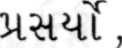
પ્રસર્યો,
